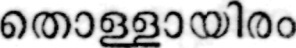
തൊള്ളായിരം
